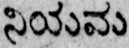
ನಿಯಮ
